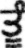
ਤੂੰ
